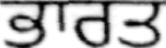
ਭਾਰਤ
